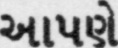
આપણે
